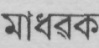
মাধৱক
